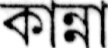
কান্না
